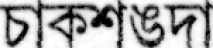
চাকশঙদা
